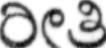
ರೀತಿ
